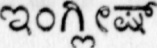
ಇಂಗ್ಲೀಷ್
